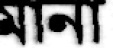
মানা
